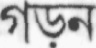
গড়ন
